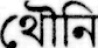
থৌনি
